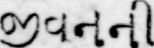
જીવનની
